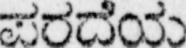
ಪರದೆಯ
